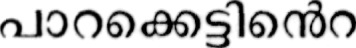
പാറക്കെട്ടിന്റെ
